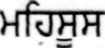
ਮਹਿਸੂਸ
